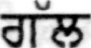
ਗੱਲ
